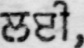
ਲਈ,
